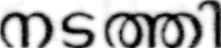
നടത്തി
